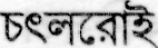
চৎলরোই
